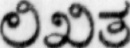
ಲಿಖಿತ
